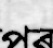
পৰ
